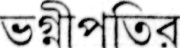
ভগ্নীপতির
